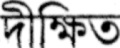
দীক্ষিত
